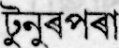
টুনুৰপৰা
